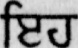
ਇਹ
